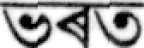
ভৰত
